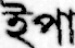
উপা
